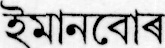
ইমানবোৰ
